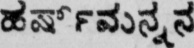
ಹರ್ಷ್‌ಮನ್ನನ
